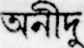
অনীদু
